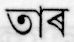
তাৰ
